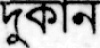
দুকান
